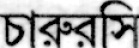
চারুরসি
